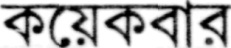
কয়েকবার
